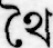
থৈ
